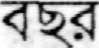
বছর
